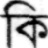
কি
